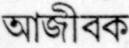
আজীবক
